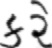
કરે
